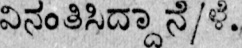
ವಿನಂತಿಸಿದ್ದಾನೆ/ಳಿ.
